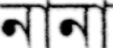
নানা
